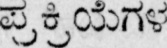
ಪ್ರಕ್ರಿಯೆಗಳ
